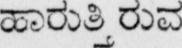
ಹಾರುತ್ತಿರುವ
